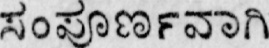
ಸಂಪೂರ್ಣವಾಗಿ
